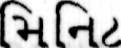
મિનિટ
